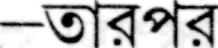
-তারপর
